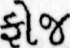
ફોજ
